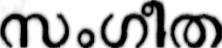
സംഗീത
